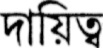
দায়িত্ব
